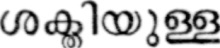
ശക്തിയുള്ള
